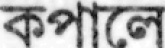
কপালে
